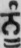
ਨੂੰ
